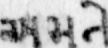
અમને
